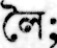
লৈ;
